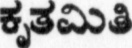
ಕೃತಮಿತಿ
